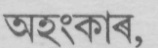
অহংকাৰ,
